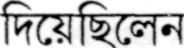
দিয়েছিলেন
